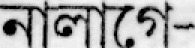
নালাগে-
